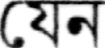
যেন
